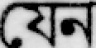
যেন
